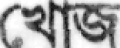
খোজ
